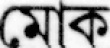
মোক
